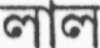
লাল
